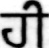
ਹੀ
